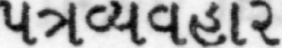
પત્રવ્યવહાર
